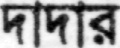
দাদার
